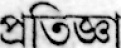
প্রতিজ্ঞা
